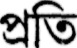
প্রতি
